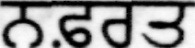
ਨਫ਼ਰਤ
